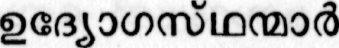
ഉദ്യോഗസ്ഥന്മാര്‍
